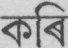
কৰি
